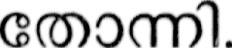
തോന്നി.
